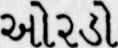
ઓરડો
